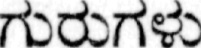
ಗುರುಗಳು
